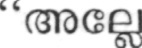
"അല്ലേ
